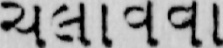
ચલાવવા
